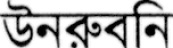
উনরুবনি
